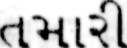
તમારી
